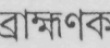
ব্রাহ্মণক
